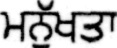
ਮਨੁੱਖਤਾ
